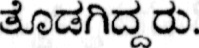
ತೊಡಗಿದ್ದರು.
